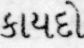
કાયદો
